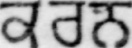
ਕਰਨ
